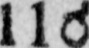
11ರ
